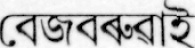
বেজবৰুৱাই
